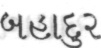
બહાદુર
